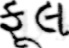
ફૂલ
